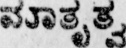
ಮಾತೃತ್ವ
